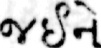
જઈને
